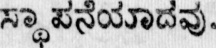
ಸ್ಥಾಪನೆಯಾದವು.
